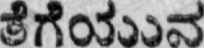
ತೆಗೆಯುವ
